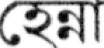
হেন্না
